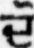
ਦੋ
